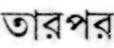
তারপর
